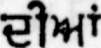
ਦੀਆਂ
